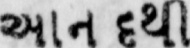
આનંદથી
